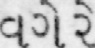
વગેરે
